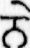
ਨੇ
